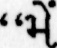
"મેં
